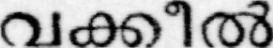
വക്കീല്‍
